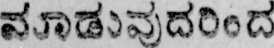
ಮಾಡುವುದರಿ೦ದ
